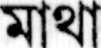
মাথা
